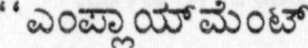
“ಎಂಪ್ಲಾಯ್‌ಮೆಂಟ್
